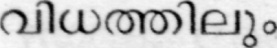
വിധത്തിലും
